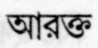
আরক্ত
